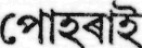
পোহৰাই
